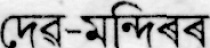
দেৱ-মন্দিৰৰ
